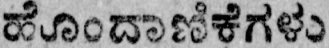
ಹೊಂದಾಣಿಕೆಗಳು
